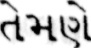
તેમણે
